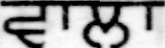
ਵਾਲਾ
